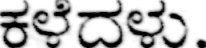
ಕಳೆದಳು.
